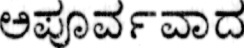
ಅಪೂರ್ವವಾದ
